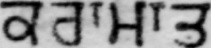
ਕਰਾਮਾਤ
